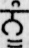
ਨੂੰ
